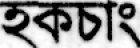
হকচাং
